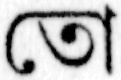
তো
